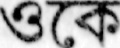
ওকে
